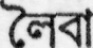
লৈবা
